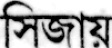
সিজায়
